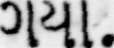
ગયા.
